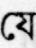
যে
